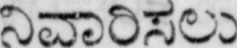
ನಿವಾರಿಸಲು
